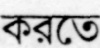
করতে
